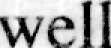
well
